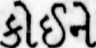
કોઈને
